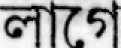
লাগে
